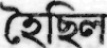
হৈছিল
